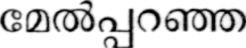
മേല്‍പ്പറഞ്ഞ
